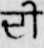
ਦੀ
